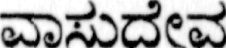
ವಾಸುದೇವ
